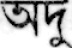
অদু
